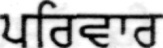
ਪਰਿਵਾਰ
